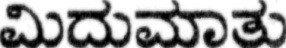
ಮಿದುಮಾತು
